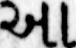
આ
